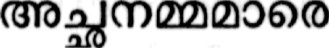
അച്ഛനമ്മമാരെ
